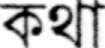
কথা
